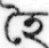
হৈ
